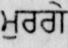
ਮੁਰਗੇ
